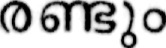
രണ്ടും
